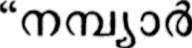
“നമ്പ്യാര്‍
